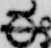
ಈ
